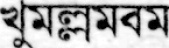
খুমল্লমবম
